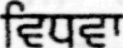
ਵਿਧਵਾ
